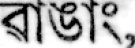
ৱাঙাং,
